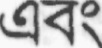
এবং
